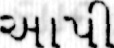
આપી
